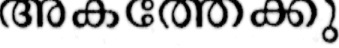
അകത്തേക്കു
